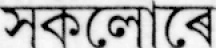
সকলোৰে
